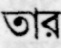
তার
